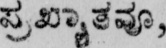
ಪ್ರಖ್ಯಾತವೂ,
